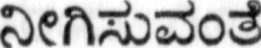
ನೀಗಿಸುವ೦ತೆ
